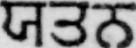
ਯਤਨ
